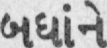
બધાંને
